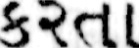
કરતા
